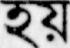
হয়
